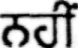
ਨਹੀਂ
